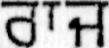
ਰਾਜ
